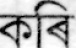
কৰি
